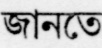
জানতে
